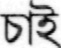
চাই
